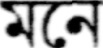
মনে
